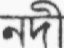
নদী
